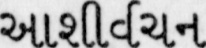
આશીર્વચન
